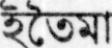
ইতৈমা
